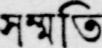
সম্মতি
